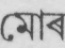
মোৰ
